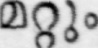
മറ്റും
